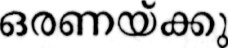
ഒരണയ്ക്കു
